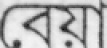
বেয়া
